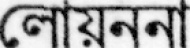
লোয়ননা
